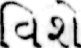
વિશે
